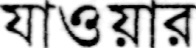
যাওয়ার
